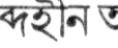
শব্দহীন
